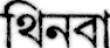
থিনবা
